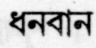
ধনবান
